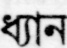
ধ্যান
